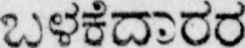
ಬಳಕೆದಾರರ
